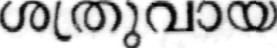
ശത്രുവായ
